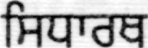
ਸਿਧਾਰਥ
